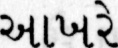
આખરે
